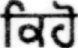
ਕਿਹੋ
